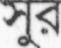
সুর
